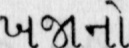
ખજાનો
